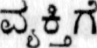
ವ್ಯಕ್ತಿಗೆ
